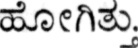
ಹೋಗಿತ್ತು.
